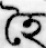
হৈ
